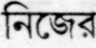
নিজের
